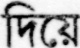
দিয়ে
